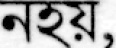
নহয়,
